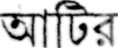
আটির
